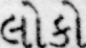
લોકો
